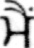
ਮੈਂ
